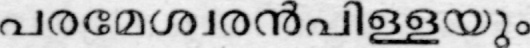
പരമേശ്വരന്‍പിള്ളയും
